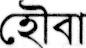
হৌবা
